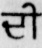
ਦੀ
